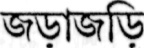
জড়াজড়ি
